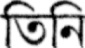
তিনি
